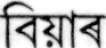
বিয়াৰ
